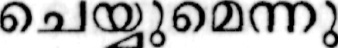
ചെയ്യുമെന്നു
